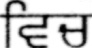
ਵਿਚ
